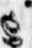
હું
